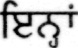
ਇਨ੍ਹਾਂ
